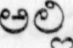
ಅಲ್ಲಿ
